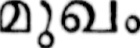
മുഖം
